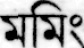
মমিং
